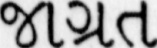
જાગ્રત
